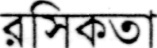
রসিকতা
